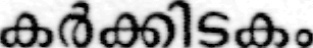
കര്‍ക്കിടകം
